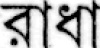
রাধা
